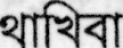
থাখিবা
